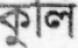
কুলি
